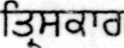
ਤ੍ਰਿਸਕਾਰ
